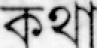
কথা
